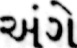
અંગે
